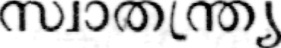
സ്വാതന്ത്ര്യ
